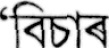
'বিচাৰ
